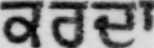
ਕਰਦਾ
